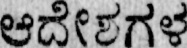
ಆದೇಶಗಳ
